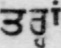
ਤਰ੍ਹਾਂ
